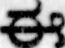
ಈ
